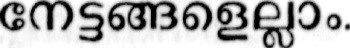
നേട്ടങ്ങളെല്ലാം.
